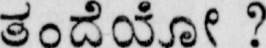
ತಂದೆಯೋ?
